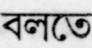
বলতে
